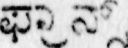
ಫ್ರಾನ್ಸ್
